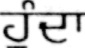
ਹੁੰਦਾ
